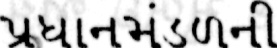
પ્રધાનમંડળની
